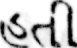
હતી
